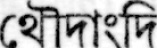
থৌদাংদি
